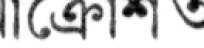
আক্ৰোশ
